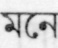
মনে
